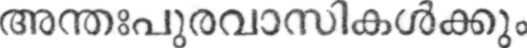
അന്തഃപുരവാസികള്‍ക്കും
